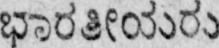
ಭಾರತೀಯರು
